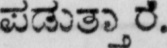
ಪಡುತ್ತಾರೆ.
